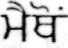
ਮੈਥੋਂ
